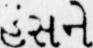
હંસને
